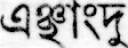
এঞ্ছাংদু
